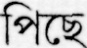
পিছে
